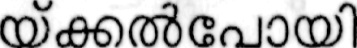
യ്ക്കല്‍പോയി
